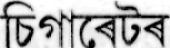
চিগাৰেটৰ
